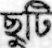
ছুটি
